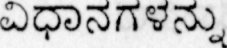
ವಿಧಾನಗಳನ್ನು
